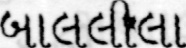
બાલલીલા
